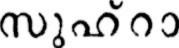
സുഹ്റാ
